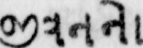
જીવનનો
